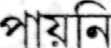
পায়নি
